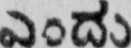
ಎಂದು
